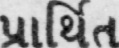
પ્રાર્થિત
